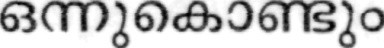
ഒന്നുകൊണ്ടും
